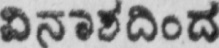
ವಿನಾಶದಿಂದ
